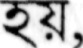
হয়,
